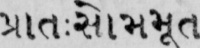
પ્રાતઃસોમમૂત
